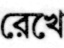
রেখে
